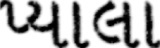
પ્યાલા
